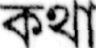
কথা
